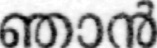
ഞാന്‍
